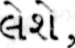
લેશે,
